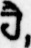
ਹੈ,
